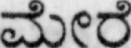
ಮೇರೆ
